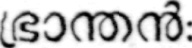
ഭ്രാന്തന്‍:
